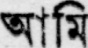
আমি
